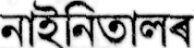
নাইনিতালৰ
